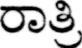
ರಾತ್ರಿ
